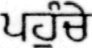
ਪਹੁੰਚੇ
